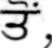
ਤੋਂ,
